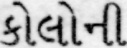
કોલોની
